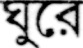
ঘুরে
